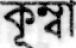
কূম্বা
